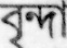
বৃন্দা
